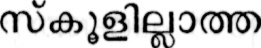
സ്കൂളില്ലാത്ത
